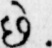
છે.
